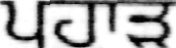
ਪਹਾੜ
